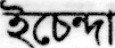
ইচেন্দা
